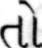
તો
